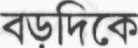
বড়দিকে
